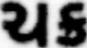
ચક્ર
